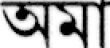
অমা
